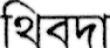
থিবদা
